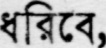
ধরিবে,
